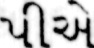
પીએ
